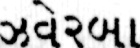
ઝવેરબા
